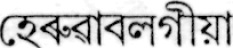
হেৰুৱাবলগীয়া
